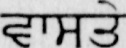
ਵਾਸਤੇ
